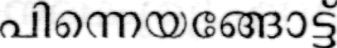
പിന്നെയങ്ങോട്ട്
